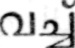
വച്ച്
